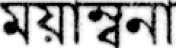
ময়াম্বনা
